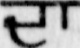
ਦਾ
